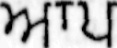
ਆਪ
